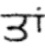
ਤਾਂ
